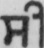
ਸੀ
